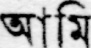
আমি
